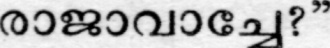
രാജാവാച്ചേ?"
